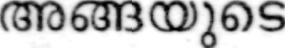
അങ്ങയുടെ
